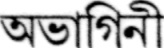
অভাগিনী
